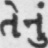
તેનું
